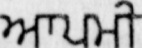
ਆਪਮੀ
